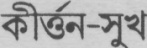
কীৰ্ত্তন-সুখ
